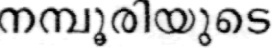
നമ്പൂരിയുടെ
